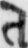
તે
